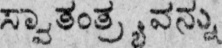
ಸ್ವಾತಂತ್ರ್ಯವನ್ನು
